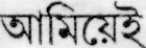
আমিয়েই
